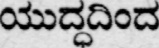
ಯುದ್ಧದಿಂದ
